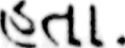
હતા.
